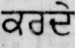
ਕਰਦੇ
